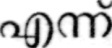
എന്ന്
